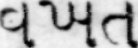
વખત
